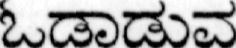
ಓಡಾಡುವ
